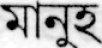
মানুহ
